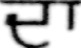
ਦਾ
